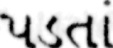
પડતાં
